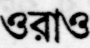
ওরাও
